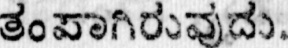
ತಂಪಾಗಿರುವುದು.
